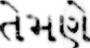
તેમણે
